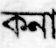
কনা
